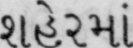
શહેરમાં
